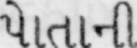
પોતાની
